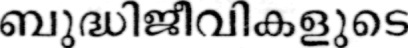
ബുദ്ധിജീവികളുടെ
